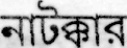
নাটক্কার
